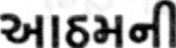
આઠમની
